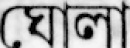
ঘোলা
